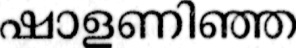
ഷാളണിഞ്ഞ
